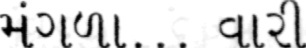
મંગળા...વારી
